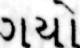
ગયો
